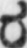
ರ
